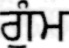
ਗੁੰਮ
